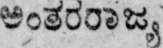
ಅಂತರರಾಜ್ಯ
